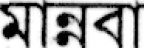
মান্নবা
